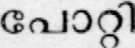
പോറ്റി
